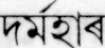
দর্মহাৰ
